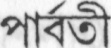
পার্বতী
